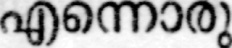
എന്നൊരു
